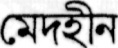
মেদহীন
